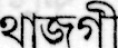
থাজগী
